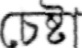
চেষ্টা
